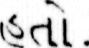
હતો.
